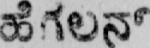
ಹೆಗಲನ್
